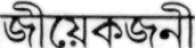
জীয়েকজনী
